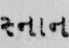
સ્નાન
